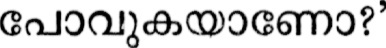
പോവുകയാണോ?’
